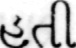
હતી
